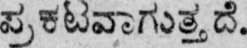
ಪ್ರಕಟವಾಗುತ್ತದೆ.
